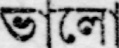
ভালো
